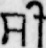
ਸੀ
